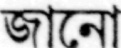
জানো
